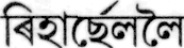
ৰিহার্ছেললৈ
